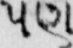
પણ
